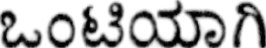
ಒಂಟಿಯಾಗಿ
